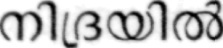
നിദ്രയില്‍
